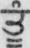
ਤੂੰ
